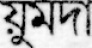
য়ুমদা
